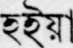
হইয়া
